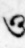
ও
